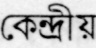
কেন্দ্রীয়
